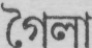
গৈলা
